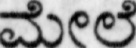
ಮೇಲೆ
